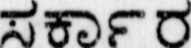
ಸರ್ಕಾರ
